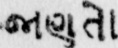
જાણતો
